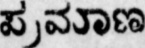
ಪ್ರಮಾಣ
